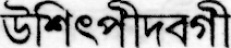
উশিৎপীদবগী
